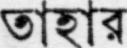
তাহার
